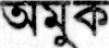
অমুক
